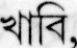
খাবি,
